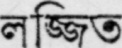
লজ্জিত
